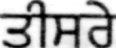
ਤੀਸਰੇ
